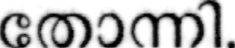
തോന്നി.
